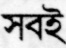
সবই
